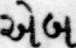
એબ
